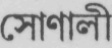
সোণালী
